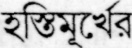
হস্তিমূর্খের
